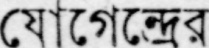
যোগেন্দ্রের
